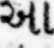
આ
